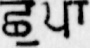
ਛੁਪਾ
